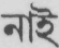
নাই
